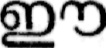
ഈ
